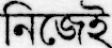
নিজেই
